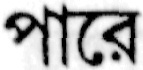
পারে
